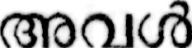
അവള്‍
